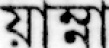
য়াম্না
